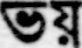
ভয়
